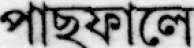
পাছফালে
